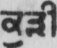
ਕੁੜੀ
